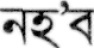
নহ'ব
